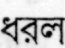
ধরল
